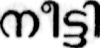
നീട്ടി
